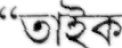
"তাইক
